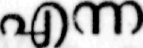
എന്ന
